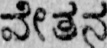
ವೇತನ
